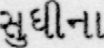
સુધીના
